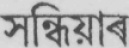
সন্ধিয়াৰ
